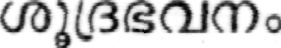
ശൂദ്രഭവനം
